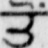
ਤੋਂ
